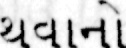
થવાનો
